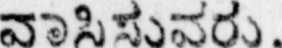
ವಾಸಿಸುವರು.
